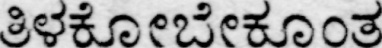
ತಿಳಕೋಬೇಕೂಂತ
